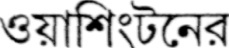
ওয়াশিংটনের
